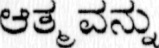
ಆತ್ಮವನ್ನು
